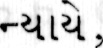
ન્યાયે,
